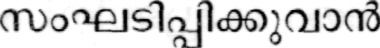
സംഘടിപ്പിക്കുവാന്‍
